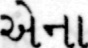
એના
